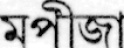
মপীজা
